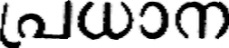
പ്രധാന
